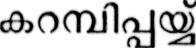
കറമ്പിപ്പയ്യ്
